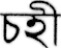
চহী
